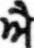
ਐ
